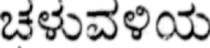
ಚಳುವಳಿಯ
